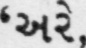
'અરે,
